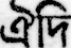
ঐদি
